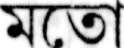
মতো
